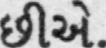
છીએ.
